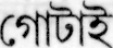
গোটাই
